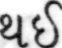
થઈ
